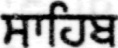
ਸਾਹਿਬ
